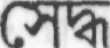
সেদ্ধ
